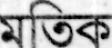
মতিক
